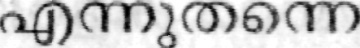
എന്നുതന്നെ
